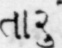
તારું
